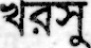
খরসু
